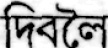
দিবলৈ
